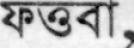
ফত্তবা,
